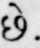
છે.
